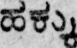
ಹಕ್ಕು
